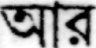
আর
